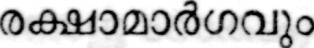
രക്ഷാമാര്‍ഗവും
